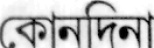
কোনদিনা
